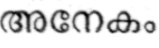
അനേകം
